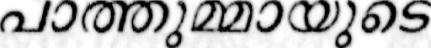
പാത്തുമ്മായുടെ
